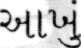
આખું
